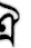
ঐ
